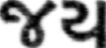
જય
